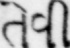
તેવી
